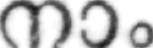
നാം
